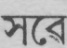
সৱে
